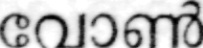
വോണ്‍
